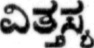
ವಿತ್ತಸ್ಯ
